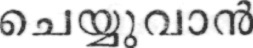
ചെയ്യുവാന്‍
